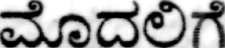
ಮೊದಲಿಗೆ
